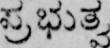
ಪ್ರಭುತ್ವ
